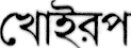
খোইরপ
